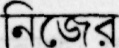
নিজের
